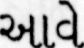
આવે
